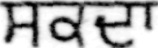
ਸਕਦਾ
